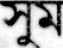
সুম
